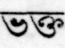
ভক্ত
